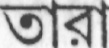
তারা
